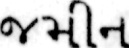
જમીન
